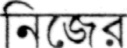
নিজের
